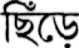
ছিঁড়ে
